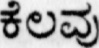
ಕೆಲವು
